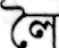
লৈ
